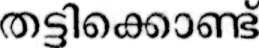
തട്ടിക്കൊണ്ട്
